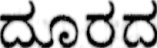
ದೂರದ
